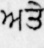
ਅਤੇ
